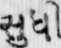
સુધી
